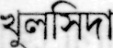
খুলসিদা
